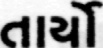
તાર્યો
